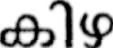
കിഴ
